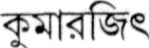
কুমারজিত্
